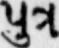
પુત્ર
